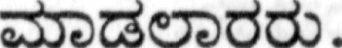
ಮಾಡಲಾರರು.
